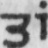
ਤਾ
